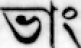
ভাং
